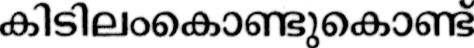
കിടിലംകൊണ്ടുകൊണ്ട്
